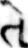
તે
